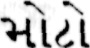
મોટો
